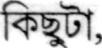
কিছুটা,
